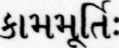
કામમૂર્તિઃ
